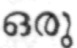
ഒരു
